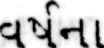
વર્ષના
